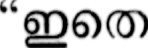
“ഇതെ
